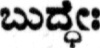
ಬುದ್ಧೇಃ
